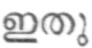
ഇതു
